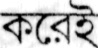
করেই
